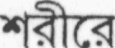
শরীরে
